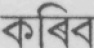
কৰিব
